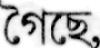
গৈছে,
